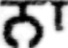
ਨਾ
